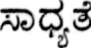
ಸಾಧ್ಯತೆ
